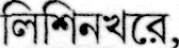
লিশিনখ্রে,
